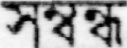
সম্বন্ধ
